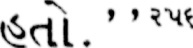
હતો."૨૫૬
